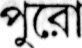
পুরো
